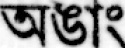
অঙাং
